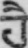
ਹੈ
